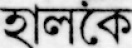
হালকে
